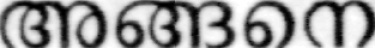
അങ്ങനെ
